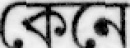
কেনে
